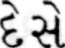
દેસે
